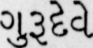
ગુરૂદેવે
